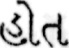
હોત
